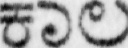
ಕಾಲ
